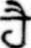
ਹੈ
